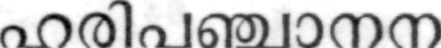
ഹരിപഞ്ചാനന
